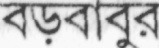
বড়বাবুর
